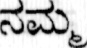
ನಮ್ಮ
